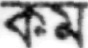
কম
